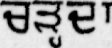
ਚੜ੍ਹਦਾ
